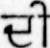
ਦੀ
